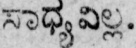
ಸಾಧ್ಯವಿಲ್ಲ.
